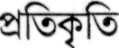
প্রতিকৃতি
